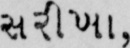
સરીખા,
